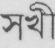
সখী
